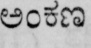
ಅಂಕಣ
